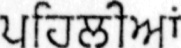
ਪਹਿਲੀਆਂ
